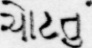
ચોટતું
